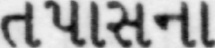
તપાસના
